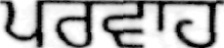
ਪਰਵਾਹ
